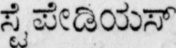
ಸ್ಟೆಪೇಡಿಯಸ್
